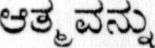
ಆತ್ಮವನ್ನು
